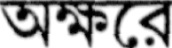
অক্ষরে
